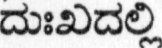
ದುಃಖದಲ್ಲಿ
